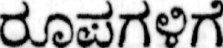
ರೂಪಗಳಿಗೆ
